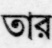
তার
